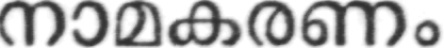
നാമകരണം
